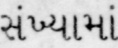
સંખ્યામાં
